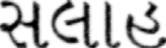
સલાહ
